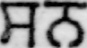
ਸਨ
